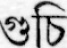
গুচি
